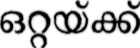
ഒറ്റയ്ക്ക്
